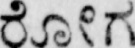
ರೋಗ
